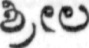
ಶ್ರೀಲ
